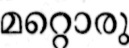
മറ്റൊരു
